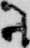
ને
